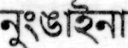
নুংঙাইনা
